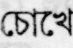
চোখে
